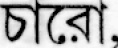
চারো,
